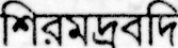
শিরমদ্রবদি
